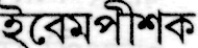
ইবেমপীশক
